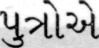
પુત્રોએ
